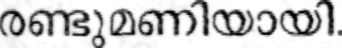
രണ്ടുമണിയായി.
